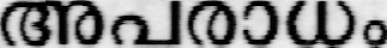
അപരാധം
